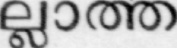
ല്ലാത്ത
